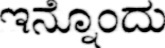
ಇನ್ನೊಂದು
